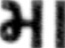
મા
